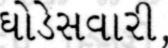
ઘોડેસવારી,
